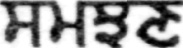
ਸਮਝਣ
